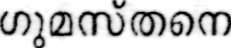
ഗുമസ്തനെ
